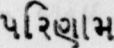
પરિણામ
